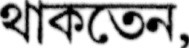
থাকতেন,
